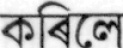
কৰিলে
